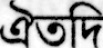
ঐতদি
